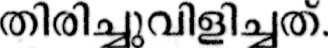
തിരിച്ചുവിളിച്ചത്.
